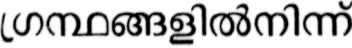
ഗ്രന്ഥങ്ങളില്‍നിന്ന്
